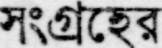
সংগ্রহের
